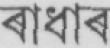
ৰাধাৰ
